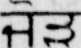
ਜੋੜ
